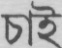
চাই
